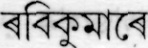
ৰবিকুমাৰে
